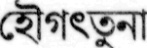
হৌগৎতুনা
